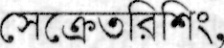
সেক্রেতরিশিং,
